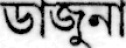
ডাজুনা
